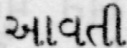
આવતી
